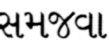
સમજવા
